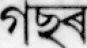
গছৰ
